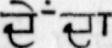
ਦੇਂਦਾ
